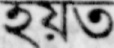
হয়ত
